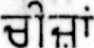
ਚੀਜ਼ਾਂ
